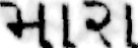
મારા
